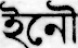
ইনৌ
